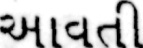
આવતી
